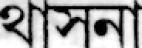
থাসনা
